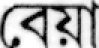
বেয়া
